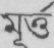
মূৰ্ত্ত
